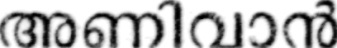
അണിവാന്‍
